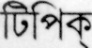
টিপিক্
